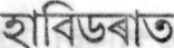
হাবিডৰাত
